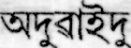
অদুৱাইদু
